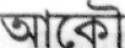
আকৌ
